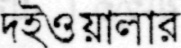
দইওয়ালার
